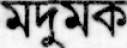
মদুমক
